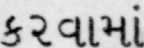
કરવામાં
